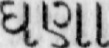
ઘણા
